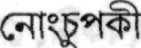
নোংচুপকী
